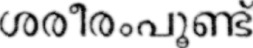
ശരീരംപൂണ്ട്
